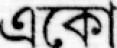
একো
